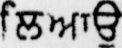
ਲਿਆਉ
